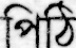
পিঠি
